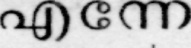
എന്നേ
